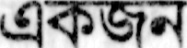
একজন
